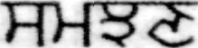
ਸਮਝਣ
